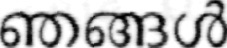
ഞങ്ങള്‍
